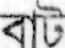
বাট
